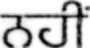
ਨਹੀਂ
